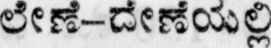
ಲೇಣೆ-ದೇಣೆಯಲ್ಲಿ
